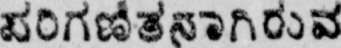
ಪರಿಗಣಿತನಾಗಿರುವ
